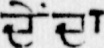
ਦੇਂਦਾ
